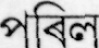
পৰিল
